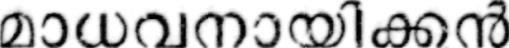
മാധവനായിക്കന്‍
